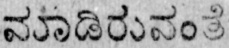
ಮಾಡಿರುವಂತೆ
